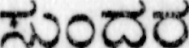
ಸುಂದರ
